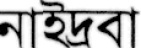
নাইদ্রবা
